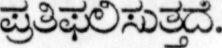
ಪ್ರತಿಫಲಿಸುತ್ತದೆ.
